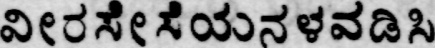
ವೀರಸೇಸೆಯನಳವಡಿಸಿ
